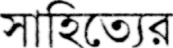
সাহিত্যের
